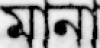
মানা
